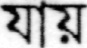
যায়
